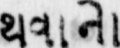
થવાનો
